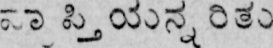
ವ್ಯಾಪ್ತಿಯನ್ನರಿತು
